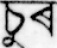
চুৰ
